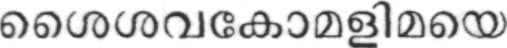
ശൈശവകോമളിമയെ
